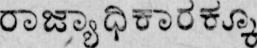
ರಾಜ್ಯಾಧಿಕಾರಕ್ಕೂ
